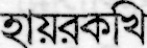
হায়রকখি
